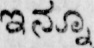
ಇನ್ನೂ
